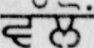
ਵੱਲੋਂ
